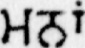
ਮਨਾਂ
